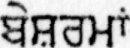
ਬੇਸ਼ਰਮਾਂ
